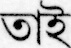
তাই
